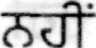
ਨਹੀਂ
